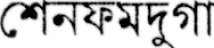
শেনফমদুগা
